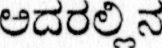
ಅದರಲ್ಲಿನ
